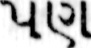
પણ
